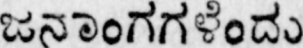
ಜನಾಂಗಗಳೆಂದು
